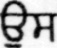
ਉਸ
